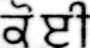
ਕੋਈ
